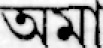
অমা
